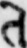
તે
